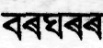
বৰঘৰৰ
